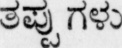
ತಪ್ಪುಗಳು
